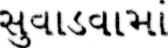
સુવાડવામાં
